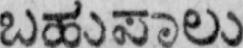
ಬಹುಪಾಲು
